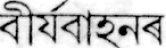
বীর্যবাহনৰ
